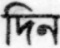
দিন
